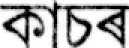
কাচৰ
